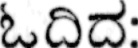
ಓದಿದ:
